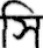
সি
